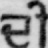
ਦੀ
